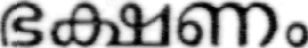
ഭക്ഷണം
